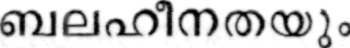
ബലഹീനതയും
